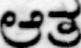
ಆತ
